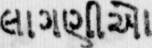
લાગણીઓ
